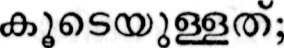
കൂടെയുള്ളത്;
